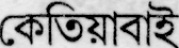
কেতিয়াবাই
